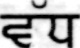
ਵੱਧ
